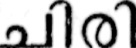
ചിരി
